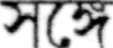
সঙ্গে
